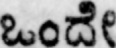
ಒಂದೇ
